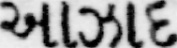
આઝાદ
